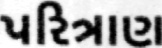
પરિત્રાણ
